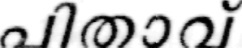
പിതാവ്
